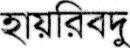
হায়রিবদু
